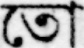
তো
